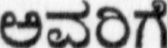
ಅವರಿಗೆ
